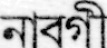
নাবগী
